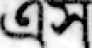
এস
